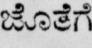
ಜೊತೆಗೆ
